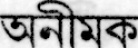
অনীমক
